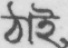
ঠাই,
